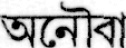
অনৌবা
